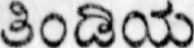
ತಿಂಡಿಯ
